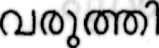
വരുത്തി
